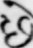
છે
